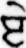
ਏ
